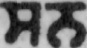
ਸਨ
